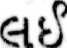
લઈ
